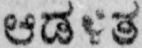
ಆಡಳಿತ
